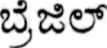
ಬ್ರೆಜಿಲ್
